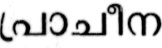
പ്രാചീന
